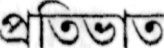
প্রতিভাত
